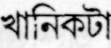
খানিকটা
